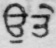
ਉਤੇ
